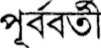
পূর্ববর্তী
